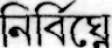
নির্বিঘ্নে
